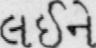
લઈને
